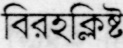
বিরহক্লিষ্ট
